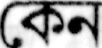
কেন
